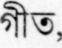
গীত,
